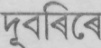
দূবৰিৰে
